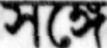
সঙ্গে
